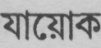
যায়োক
